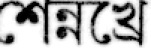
শেন্নখ্রে
